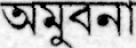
অমুবনা
